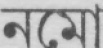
নমো
